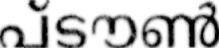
പ്ടൌണ്‍
